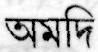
অমদি
